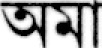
অমা
